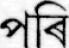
পৰি
